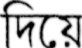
দিয়ে
